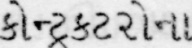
કોન્ટ્રાકટરોના
